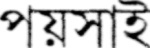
পয়সাই
